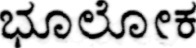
ಭೂಲೋಕ
